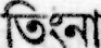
তিংনা
